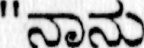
“ನಾನು
